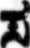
ಸ
